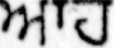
ਆਹ
